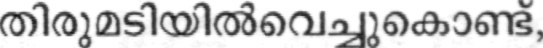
തിരുമടിയില്‍വെച്ചുകൊണ്ട്,
